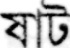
ষাট
